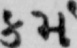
કર્મ
